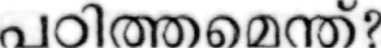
പഠിത്തമെന്ത്?
